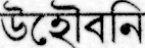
উহৌবনি
